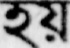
হয়
